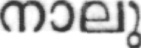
നാലു
